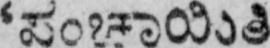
‘ಪಂಚಾಯಿತಿ
